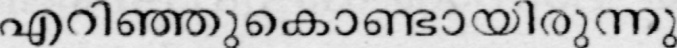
എറിഞ്ഞുകൊണ്ടായിരുന്നു
